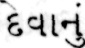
દેવાનું
